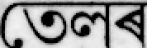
তেলৰ
